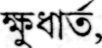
ক্ষুধার্ত,
